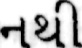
નથી
